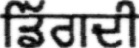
ਡਿੱਗਦੀ
